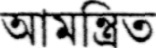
আমন্ত্রিত
